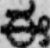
ಈ
